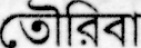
তৌরিবা
